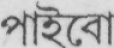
পাইবো
